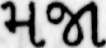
મજા
